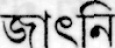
জাৎনি
